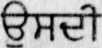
ਉਸਦੀ
